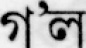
গ'ল
